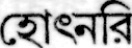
হোৎনরি
